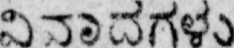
ವಿವಾದಗಳು
